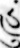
હું
